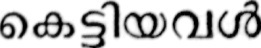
കെട്ടിയവള്‍
